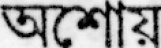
অশোয়
